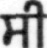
ਸੀ
